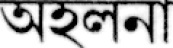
অহলনা
